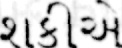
શકીએ
